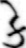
કે
